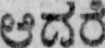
ಆದರೆ
